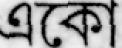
একো
